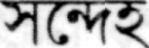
সন্দেহ
